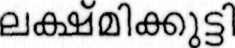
ലക്ഷ്മിക്കുട്ടി
